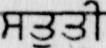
ਸਤੁਤੀ
